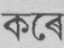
কৰে
